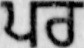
ਪਰ
